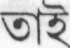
তাই
